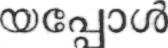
യപ്പോള്‍
